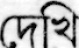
দেখি
